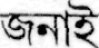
জনাই
